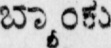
ಬ್ಯಾಂಕು
